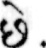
છે.
